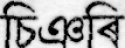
চিঞৰি
